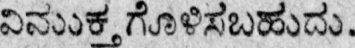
ವಿಮುಕ್ತಗೊಳಿಸಬಹುದು.
